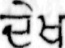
ਦੇਖ
